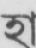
হা
